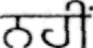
ਨਹੀਂ
